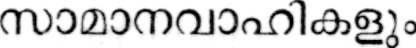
സാമാനവാഹികളും
